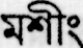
মশীং
